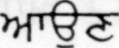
ਆਉਣ
